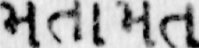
મતામત
